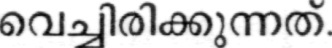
വെച്ചിരിക്കുന്നത്.
